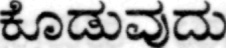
ಕೊಡುವುದು
